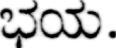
ಭಯ.
